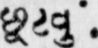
છૂટવું.
